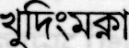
খুদিংমক্না
